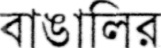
বাঙালির
